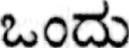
ಒಂದು
